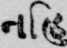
નહિ
